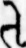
તે
